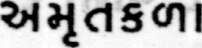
અમૃતકળા
